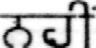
ਨਹੀਂ
